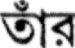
তাঁর
